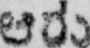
ಆರು
